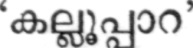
‘കല്ലൂപ്പാറ’
